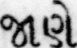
જાણે
